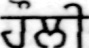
ਹੌਲੀ
